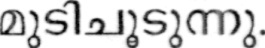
മുടിചൂടുന്നു.
